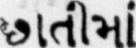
છાતીમાં
